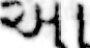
આ
